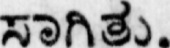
ಸಾಗಿತು.
